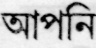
আপনি
